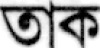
তাক
